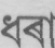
ধৰা
